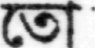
তো
